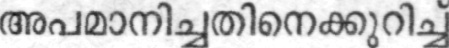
അപമാനിച്ചതിനെക്കുറിച്ച്
